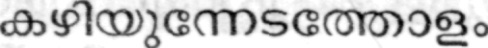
കഴിയുന്നേടത്തോളം
